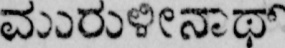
ಮುರುಳೀನಾಥ್
